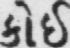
કોઈ
